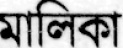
মালিকা
